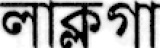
লাক্লগা
